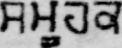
ਸਮੂਹਕ
